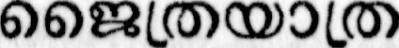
ജൈത്രയാത്ര
